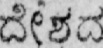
ದೇಶದ
